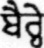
ਬੈਰ੍ਹੇ
